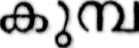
കുമ്പ
